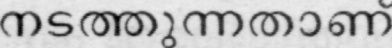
നടത്തുന്നതാണ്
